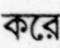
করে
